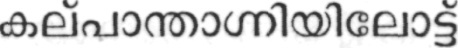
കല്പാന്താഗ്നിയിലോട്ട്
